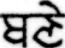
ਬਣੇ
